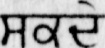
ਸਕਦੇ
